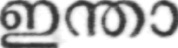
ഇന്താ
